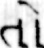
તો
